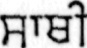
ਸਾਥੀ
